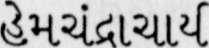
હેમચંદ્રાચાર્ય
